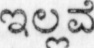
ಇಲ್ಲವೆ
